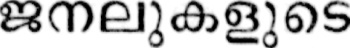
ജനലുകളുടെ
